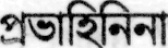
প্রভাহিনিনা
